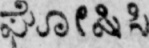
ಘೋಷಿಸಿ
